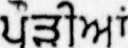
ਪੌੜੀਆਂ
